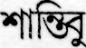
শান্তিবু
